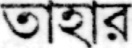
তাহার
